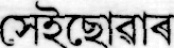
সেইছোৱাৰ
